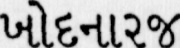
ખોદનારજ
